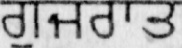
ਗੁਜਰਾਤ
